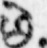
છે.
